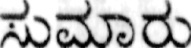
ಸುಮಾರು
